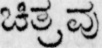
ಚಿತ್ರವು
